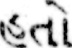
હતો
